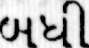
બધી
